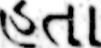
હતા
